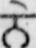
ਨੇ
